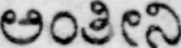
ಅಂತೀನಿ
